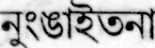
নুংঙাইতনা
